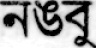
নঙবু
